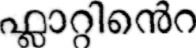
ഫ്ലാറ്റിന്റെ
